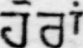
ਹੋਰਾਂ
